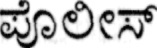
ಪೊಲೀಸ್
